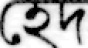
হেদ
